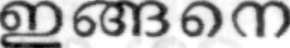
ഇങ്ങനെ
